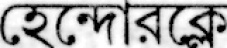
হেন্দোরক্লে
